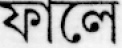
ফালে
